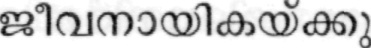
ജീവനായികയ്ക്കു
